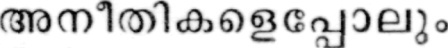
അനീതികളെപ്പോലും
